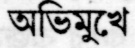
অভিমুখে
